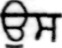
ਉਸ
